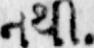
નથી.
